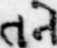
તને
